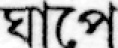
ঘাপে
